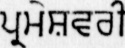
ਪ੍ਰਮੇਸ਼ਵਰੀ
